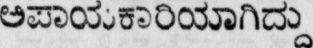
ಅಪಾಯಕಾರಿಯಾಗಿದ್ದು
